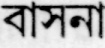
বাসনা
